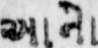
આનો
